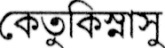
কেতুকিস্নাসু
